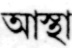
আস্থা
